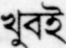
খুবই
